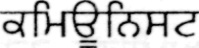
ਕਮਿਊਨਿਸਟ
